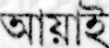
আয়াই
